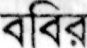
ববির
